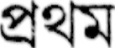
প্রথম
